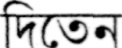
দিতেন
